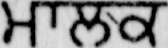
ਮਾਲਕ
